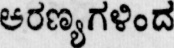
ಅರಣ್ಯಗಳಿಂದ
